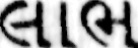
લાભ
